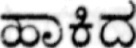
ಹಾಕಿದ
